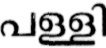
പള്ളി
